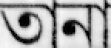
তানা
